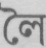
লৈ
